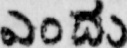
ಎಂದು
